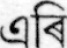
এৰি
